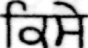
ਕਿਸੇ
